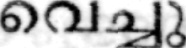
വെച്ചു
